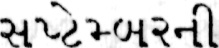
સપ્ટેમ્બરની
